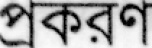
প্রকরণ
